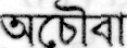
অচৌবা
